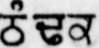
ਠੰਢਕ
